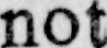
not
